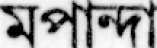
মপান্দা
